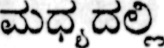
ಮಧ್ಯದಲ್ಲಿ
